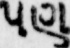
પણ
